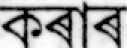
কৰাৰ
